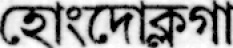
হোংদোক্লগা
